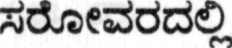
ಸರೋವರದಲ್ಲಿ
